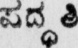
ಪದ್ಧತಿ
